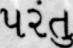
પરંતુ
